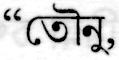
“তৌনু,
